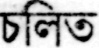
চলিত
